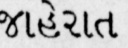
જાહેરાત
